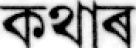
কথাৰ
